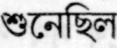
শুনেছিল
